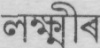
লক্ষ্মীৰ
